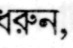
ধরুন,
